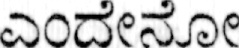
ಎಂದೇನೋ
